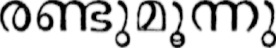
രണ്ടുമൂന്നു
